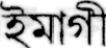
ইমাগী
